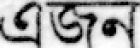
এজন
